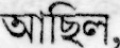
আছিল,
